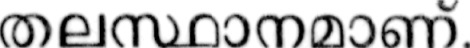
തലസ്ഥാനമാണ്.
